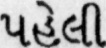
પહેલી
